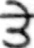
ਤੇ
